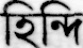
হিন্দি
